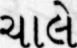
ચાલે
